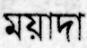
ময়াদা
